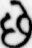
છે
